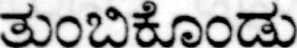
ತುಂಬಿಕೊಂಡು
